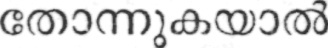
തോന്നുകയാല്‍
